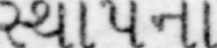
સ્થાપના
